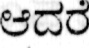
ಆದರೆ
